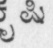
ಕೃಷಿ
